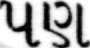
પણ
